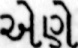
એણે
